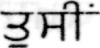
ਤੁਸੀਂ
